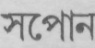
সপোন
